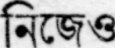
নিজেও
